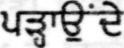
ਪੜ੍ਹਾਉਂਦੇ
